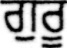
ਗੁਰੂ
